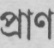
প্ৰাণ
